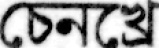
চেনখ্রে
